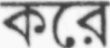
করে
